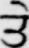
ਤੇ
